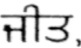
ਜੀਤ,
